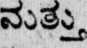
ಮತ್ತು
